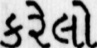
કરેલો
